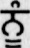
ਨੂੰ
